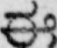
ಈ
